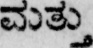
ಮತ್ತು
